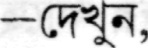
-দেখুন,
